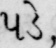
પડે,
